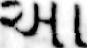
આ
